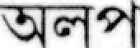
অলপ
